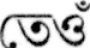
তেওঁ
